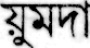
য়ুমদা
